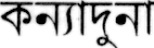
কন্যাদুনা
